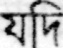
যদি
